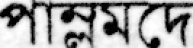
পাম্লমদে
